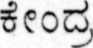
ಕೇಂದ್ರ
